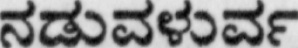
ನಡುವಳುರ್ವ
